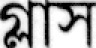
গ্লাস
